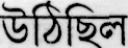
উঠিছিল
